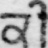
ਕੀ
